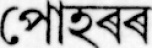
পোহৰৰ
